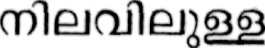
നിലവിലുള്ള
